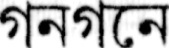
গনগনে
